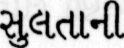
સુલતાની
